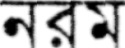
নরম
